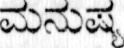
ಮನುಷ್ಯ
